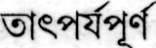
তাৎপর্যপূর্ণ
